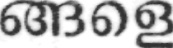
ങ്ങളെ
